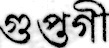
গুপ্তগী
